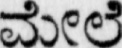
ಮೇಲೆ
